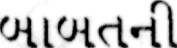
બાબતની
